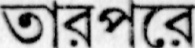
তারপরে
